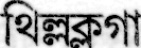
থিল্লক্লগা
